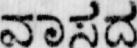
ವಾಸದ
